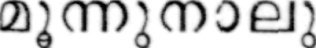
മൂന്നുനാലു
